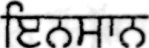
ਇਨਸਾਨ
